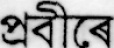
প্রবীৰে
